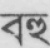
বহু
